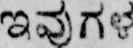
ಇವುಗಳ
